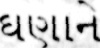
ઘણાને
